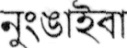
নুংঙাইবা
